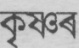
কৃষ্ণৰ
